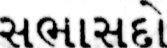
સભાસદો
